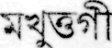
মখুত্তগী
